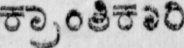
ಕ್ರಾಂತಿಕಾರಿ
